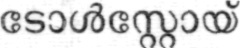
ടോള്‍സ്റ്റോയ്
